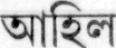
আহিল
